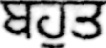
ਬਹੁਤ
